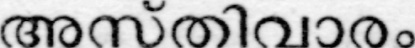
അസ്തിവാരം
